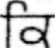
ਕਿ
